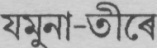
যমুনা-তীৰে
